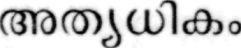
അത്യധികം
